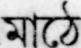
মাঠে
